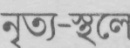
নৃত্য-স্থলে
